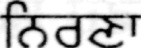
ਨਿਰਣਾ
